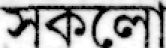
সকলো
